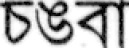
চঙবা
